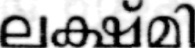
ലക്ഷ്മി
